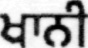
ਖਾਨੀ
